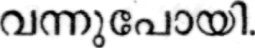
വന്നുപോയി.
